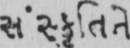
સંસ્કુતિને
